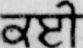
ਕਈ
